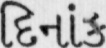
દિનાંક
